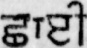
ਛਾਈ
